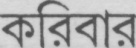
করিবার
